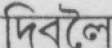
দিবলৈ
